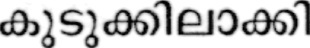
കുടുക്കിലാക്കി
